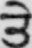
ਤੇ
